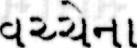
વચ્ચેના
